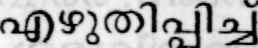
എഴുതിപ്പിച്ച്
